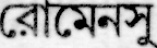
রোমেনসু
